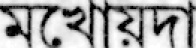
মখোয়দা
